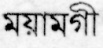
ময়ামগী
